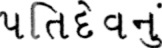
પતિદેવનું
